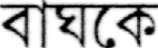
বাঘকে
